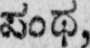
ಪಂಥ,
